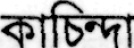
কাচিন্দা
